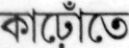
কাঢ়োঁতে
